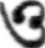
ও
